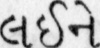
લઈને
